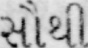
સૌથી
